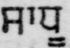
ਸਾਧੂ
